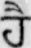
ਹੈ
